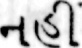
નહીં
